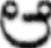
ಆ
